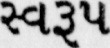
સ્વરૂપ
